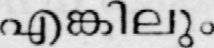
എങ്കിലും
